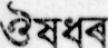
ঔষধৰ
